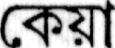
কেয়া
